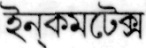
ইন্‌কমটেক্স
